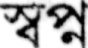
স্বপ্ন
